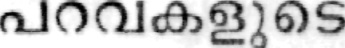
പറവകളുടെ
